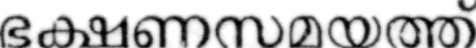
ഭക്ഷണസമയത്ത്
